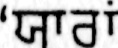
'ਯਾਰਾਂ
